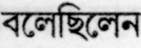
বলেছিলেন
